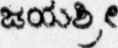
ಜಯಶ್ರೀ
